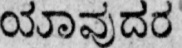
ಯಾವುದರ
